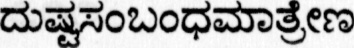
ದುಷ್ಟಸಂಬಂಧಮಾತ್ರೇಣ
